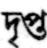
দৃপ্ত
